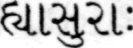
હ્યાસુરાઃ
